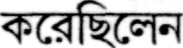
করেছিলেন
